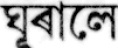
ঘূৰালে
